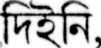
দিইনি,
